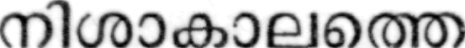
നിശാകാലത്തെ
